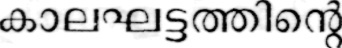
കാലഘട്ടത്തിന്റെ
